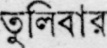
তুলিবার
